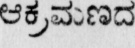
ಆಕ್ರಮಣದ
